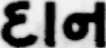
દાન
